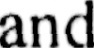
and
